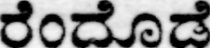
ರೆಂದೊಡೆ
